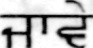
ਜਾਵੇ
